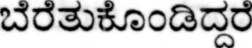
ಬೆರೆತುಕೊಂಡಿದ್ದರೆ
